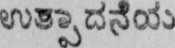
ಉತ್ಪಾದನೆಯ
